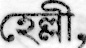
হেল্লী,
